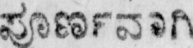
ಪೂರ್ಣವಾಗಿ
